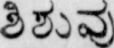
ಶಿಶುವು
